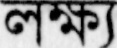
লক্ষ্য
